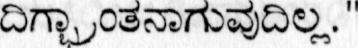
ದಿಗ್ಭ್ರಾಂತನಾಗುವುದಿಲ್ಲ.”
